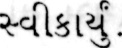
સ્વીકાર્યું.
